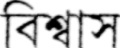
বিশ্বাস
